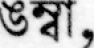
ঙম্বা,
